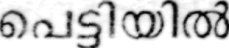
പെട്ടിയില്‍
